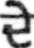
ਦੇ
